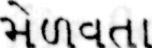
મેળવતા
